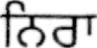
ਨਿਰਾ
